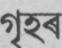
গৃহৰ
